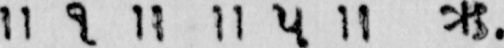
||૧||||૫||ઋ.
